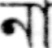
না
